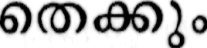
തെക്കും
